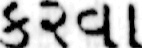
કરવા
